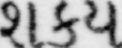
શક્ય
